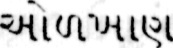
ઓળખાણ
